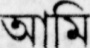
আমি
